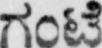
ಗಂಟೆ
